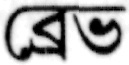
ব্রেভ
